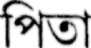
পিতা
